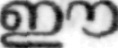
ഈ
